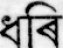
ধৰি
